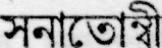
সনাতোম্বী
